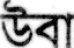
উবা
